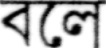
বলে
